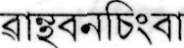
ৱান্থবনচিংবা
